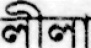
লীলা
